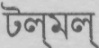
টলমল্
